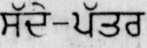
ਸੱਦੇ-ਪੱਤਰ
